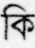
কি
